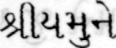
શ્રીયમુને
